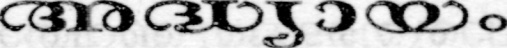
അദ്ധ്യായം
